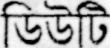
ডিউটি
